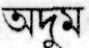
অদুম
